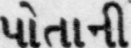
પોતાની
